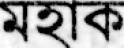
মহাক
